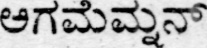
ಅಗಮೆಮ್ನನ್
